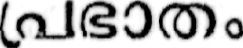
പ്രഭാതം
